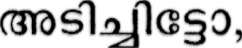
അടിച്ചിട്ടോ,
